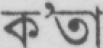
ক'তা
